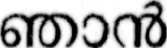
ഞാന്‍
